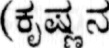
(ಕೃಷ್ಣನ
